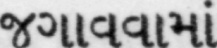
જગાવવામાં
